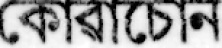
কোৱাচোন
